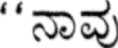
"ನಾವು
